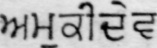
ਅਮੁਕੀਦੇਵ
